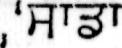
''ਸਾਡਾ
